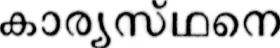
കാര്യസ്ഥനെ
